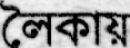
লৈকায়
